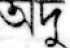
অদু
